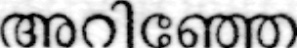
അറിഞ്ഞേ
